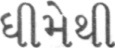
ધીમેથી
